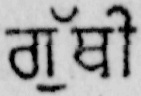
ਗੁੱਥੀ
